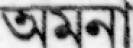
অমনা
